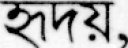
হৃদয়,
